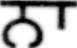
ਨਾ
